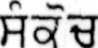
ਸੰਕੋਚ
